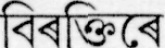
বিৰক্তিৰে
